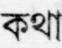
কথা
